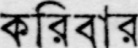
করিবার
